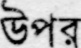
উপর
